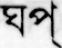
ঘপ্
